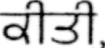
ਕੀਤੀ,
